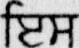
ਇਸ
